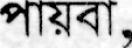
পায়বা,
